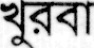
খুরবা
